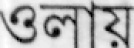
ওলায়
